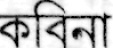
কবিনা
